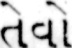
તેવો
